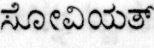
ಸೋವಿಯತ್
